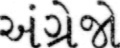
અંગ્રેજો
